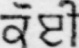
ਕੋਈ
